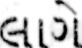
લાગે
